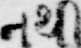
નથી
